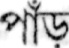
পাঁড়
